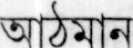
আঠমান
